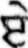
ਏ
